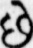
છે
